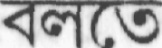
বলতে
